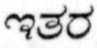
ಇತರ
